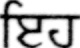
ਇਹ
